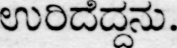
ಉರಿದೆದ್ದನು.
